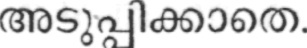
അടുപ്പിക്കാതെ.
